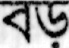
বড়
